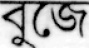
বুজে
